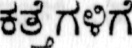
ಕತ್ತೆಗಳಿಗೆ
